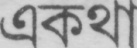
একথা
